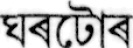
ঘৰটোৰ
